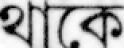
থাকে
